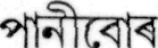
পানীবোৰ
